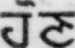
ਹੋਣ
